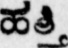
ಹತ್ತಿ
